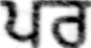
ਪਰ
